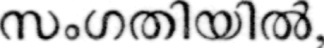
സംഗതിയില്‍,
